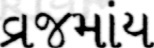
વ્રજમાંય
